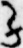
કે
